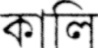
কালি
